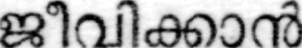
ജീവിക്കാന്‍
